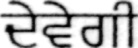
ਦੇਵੇਗੀ
